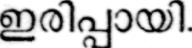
ഇരിപ്പായി.
